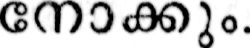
നോക്കും.
